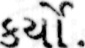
કર્યો.
